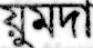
য়ুমদা
